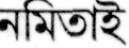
নমিতাই
